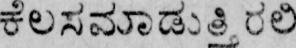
ಕೆಲಸಮಾಡುತ್ತಿರಲಿ
